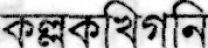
কল্লকখিগনি
